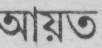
আয়ত
